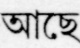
আছে
